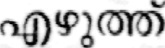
എഴുത്ത്
